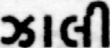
ઝાલી
